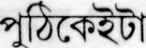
পুঠিকেইটা
